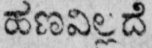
ಹಣವಿಲ್ಲದೆ
